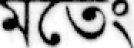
মতেং
